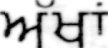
ਅੱਖਾਂ
